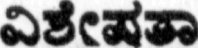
ವಿಶೇಷತಾ
